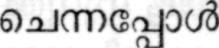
ചെന്നപ്പോള്‍
